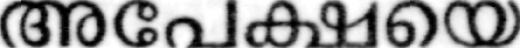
അപേക്ഷയെ
